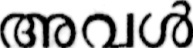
അവള്‍
